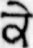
ਕੇ
